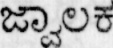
ಜ್ವಾಲಕ
